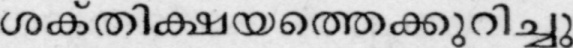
ശക്തിക്ഷയത്തെക്കുറിച്ചു
